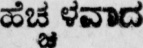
ಹೆಚ್ಚಳವಾದ
